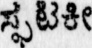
ಸ್ಛಟಿಕೀ
